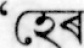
'হেৰ
